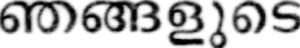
ഞങ്ങളുടെ
